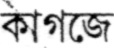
কাগজে
